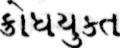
ક્રોધયુક્ત
